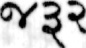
જરૂર
